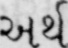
અર્થ
